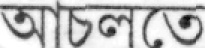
আচলতে
